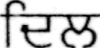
ਦਿਲ
